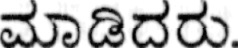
ಮಾಡಿದರು.
